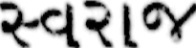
સ્વરાજ
